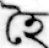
হৈ
